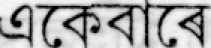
একেবাৰে
